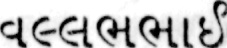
વલ્લભભાઈ
